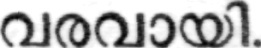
വരവായി.
